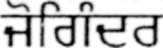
ਜੋਗਿੰਦਰ
